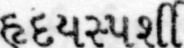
હ્દયસ્પર્શી
